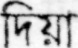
দিয়া
